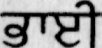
ਭਾਈ
